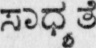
ಸಾಧ್ಯತೆ
